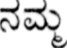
ನಮ್ಮ
